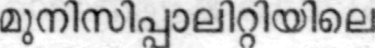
മുനിസിപ്പാലിറ്റിയിലെ
